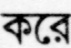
করে
